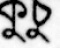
কুচু
